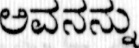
ಅವನನ್ನು
